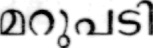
മറുപടി
